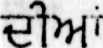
ਦੀਆਂ
